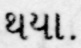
થયા.
